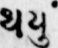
થયું
